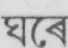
ঘৰে
